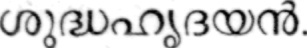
ശുദ്ധഹൃദയന്‍.
